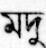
মদু
